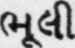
ભૂલી
